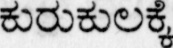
ಕುರುಕುಲಕ್ಕೆ
